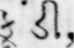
કુડી,
